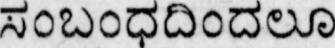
ಸಂಬಂಧದಿಂದಲೂ
